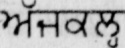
ਅੱਜਕਲ੍ਹ
